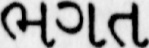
ભગત
